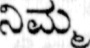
ನಿಮ್ಮ
